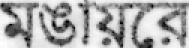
মঙায়রে
